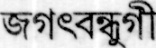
জগৎবন্ধুগী
